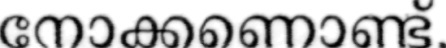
നോക്കണൊണ്ട്.
